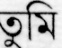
তুমি
